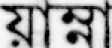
য়াম্না
